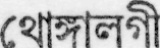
থোঙ্গালগী
